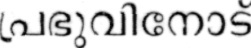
പ്രഭുവിനോട്
